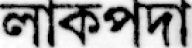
লাকপদা
